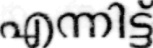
എന്നിട്ട്
